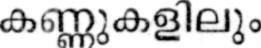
കണ്ണുകളിലും
